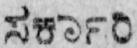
ಸರ್ಕಾರಿ
